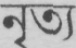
নৃত্য
